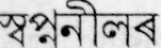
স্বপ্ননীলৰ
